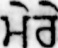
ਮੇਰੇ
